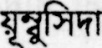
য়ূম্বুসিদা
